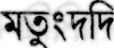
মতুংদদি
